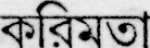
করিমতা
